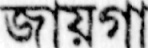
জায়গা
